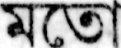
মতো
